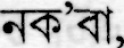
নক'বা,
